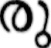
രു
